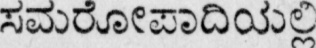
ಸಮರೋಪಾದಿಯಲ್ಲಿ
